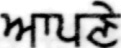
ਆਪਣੇ
